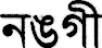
নঙগী
